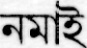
নমাই
